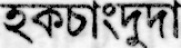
হকচাংদুদা
